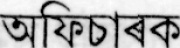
অফিচাৰক
